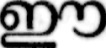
ഈ
